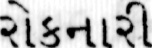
રોકનારી
